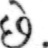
છે.
